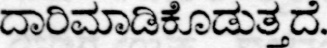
ದಾರಿಮಾಡಿಕೊಡುತ್ತದೆ.
